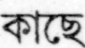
কাছে
